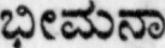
ಭೀಮನಾ
